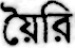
য়ৈরি
